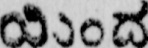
ಯಿಂದ
